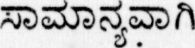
ಸಾಮಾನ್ಯವಾಗಿ
